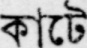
কাটে
